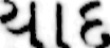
યાદ
